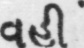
વહી
